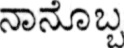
ನಾನೊಬ್ಬ
